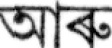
আৰু
